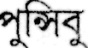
পুন্সিবু
